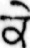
ਕੇ
